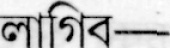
লাগিব-
